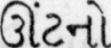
ઊંટનો
